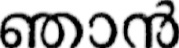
ഞാന്‍
